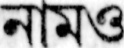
নামও
